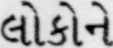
લોકોને
